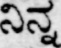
ನಿನ್ನ
